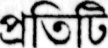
প্রতিটি
